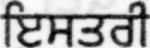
ਇਸਤਰੀ
